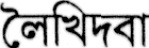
লৈখিদবা
